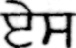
ਏਸ
